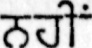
ਨਹੀਂ
